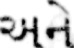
અને
